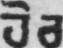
ਹੋਰ
